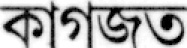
কাগজত
